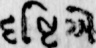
દષ્ટિએ
